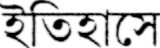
ইতিহাসে
